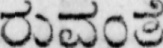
ರುವಂತೆ
